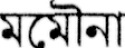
মমৌনা
